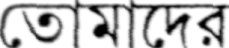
তোমাদের
